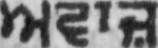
ਅਵਾਜ਼
